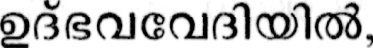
ഉദ്ഭവവേദിയില്‍,
